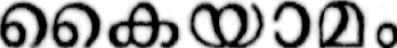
കൈയാമം
